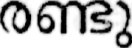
രണ്ടു
